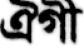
ঐগী
